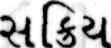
સક્રિય
